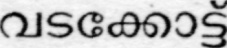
വടക്കോട്ട്
